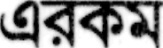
এরকম
